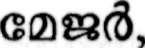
മേജര്‍,
